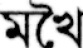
মখৈ
